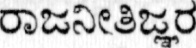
ರಾಜನೀತಿಜ್ಞರ
